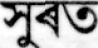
সুৰত
